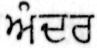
ਅੰਦਰ
